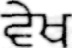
ਵੇਖ
